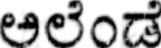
ಅಲೆಂಡೆ
